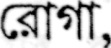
রোগা,
